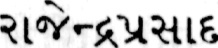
રાજેન્દ્રપ્રસાદ
